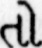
તો
